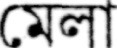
মেলা
